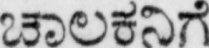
ಚಾಲಕನಿಗೆ
